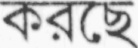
করছে
